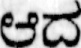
ಆದ
